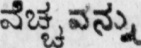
ವೆಚ್ಚವನ್ನು
